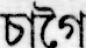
চাগৈ
